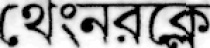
থেংনরক্লে
